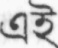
এই
